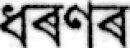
ধৰণৰ
